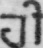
ਹੀ
